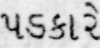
પડકારે
